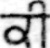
ਕੀ
